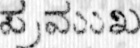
ಪ್ರಮುಖ
